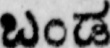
ಬಂಡ
